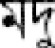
মদু
